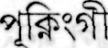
পূক্নিংগী
